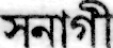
সনাগী
